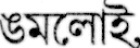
ঙমলোই,
